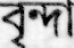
বৃন্দা
